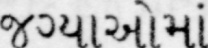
જગ્યાઓમાં
